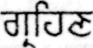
ਗ੍ਰਹਿਣ
